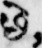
છે,
